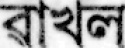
ৱাখল
